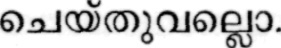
ചെയ്തുവല്ലൊ.
